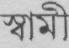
স্বামী
